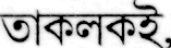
তাকলকই,
